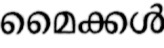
മൈക്കള്‍
